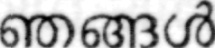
ഞങ്ങള്‍
